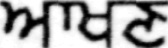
ਆਖਣ
